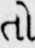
તો
